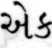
એક
